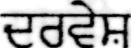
ਦਰਵੇਸ਼
